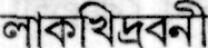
লাকখিদ্রবনী
